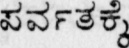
ಪರ್ವತಕ್ಕೆ
